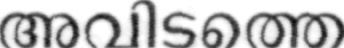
അവിടത്തെ
